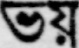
ভয়
